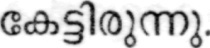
കേട്ടിരുന്നു.
